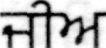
ਜੀਅ
